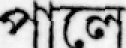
পালে
